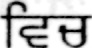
ਵਿਚ
